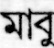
মাবু
